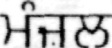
ਮੰਜ਼ਲ
